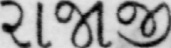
રાજાજી
